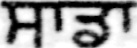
ਸਾਡਾ
